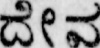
ದೇವ
